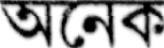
অনেক
